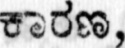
ಕಾರಣ,
